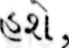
હશે,
